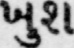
ખુશ
